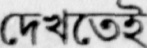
দেখতেই
